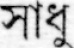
সাধু
